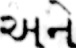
અને
